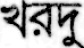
খরদু
